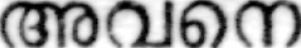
അവനെ
